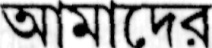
আমাদের
